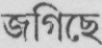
জগিছে
